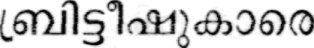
ബ്രിട്ടീഷുകാരെ
